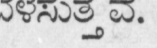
ಬೆಳೆಸುತ್ತವೆ.
